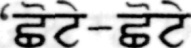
'ਛੋਟੇ-ਛੋਟੇ
